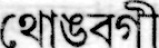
থোঙবগী
